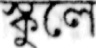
স্কুলে
